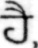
ਹੈ,
